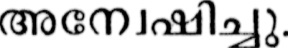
അന്വേഷിച്ചു.
